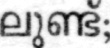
ലുണ്ട്;
